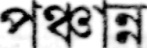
পঞ্চান্ন
